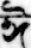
ঈ
